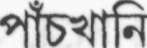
পাঁচখানি
